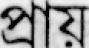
প্রায়
